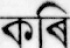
কৰি
